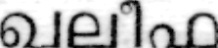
ഖലീഫ
